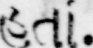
હતાં.
